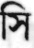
সি
